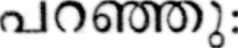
പറഞ്ഞു:
